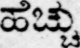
ಹೆಚ್ಚು
